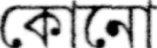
কোনো
